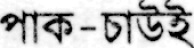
পাক-চাউই
